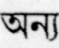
অন্য
